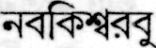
নবকিশ্বরবু
